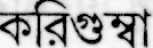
করিগুম্বা
